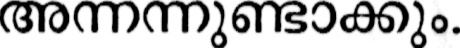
അന്നന്നുണ്ടാക്കും.
